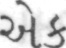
એક
